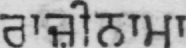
ਰਾਜ਼ੀਨਾਮਾ
